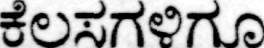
ಕೆಲಸಗಳಿಗೂ
